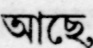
আছে,
